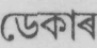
ডেকাৰ
